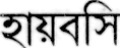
হায়বসি
